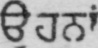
ਉਹਨਾਂ
